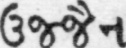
ઉજ્જૈન
